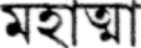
মহাত্মা
